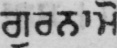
ਗੁਰਨਾਮੋ
